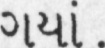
ગયાં.
